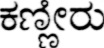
ಕಣ್ಣೀರು
